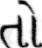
તો
